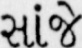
સાંજે
